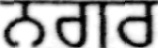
ਨਗਰ
